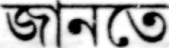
জানতে
